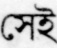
সেই
